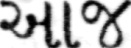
આજ
